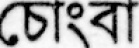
চোংবা
